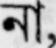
না,
